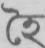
হৈ
